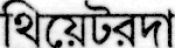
থিয়েটরদা
